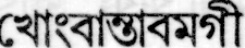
খোংবান্তাবমগী
